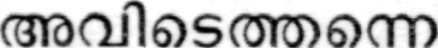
അവിടെത്തന്നെ
